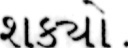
શક્યો.
